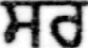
ਸਰ
